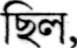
ছিল,
